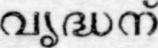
വൃദ്ധന്
